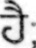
ਹੈ;
